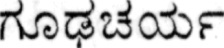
ಗೂಢಚರ್ಯ
